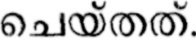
ചെയ്തത്.
